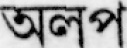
অলপ
